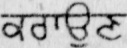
ਕਰਾਉਣ
